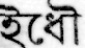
ইধৌ
